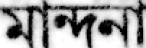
মান্দনা
